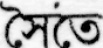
সৈতে
